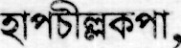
হাপচীল্লকপা,
